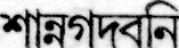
শান্নগদবনি
